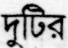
দুটির
